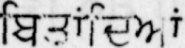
ਬਿਤਾਂਦਿਆਂ
